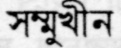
সম্মুখীন
